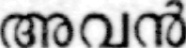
അവന്‍
